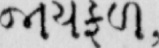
જાયફળ,
